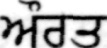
ਔਰਤ
